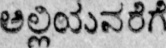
ಅಲ್ಲಿಯವರೆಗೆ
